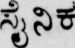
ಸೈನಿಕ
